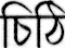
চিঠি
